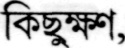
কিছুক্ষণ,
